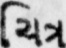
ચિત્ર
